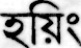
হয়িং
